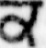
ਕ
